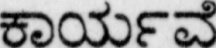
ಕಾರ್ಯವೆ
